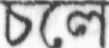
চলে
